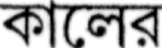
কালের
